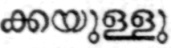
ക്കയുള്ളു
